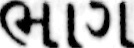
ભાગ
